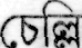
চেল্লি
